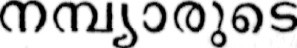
നമ്പ്യാരുടെ
